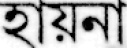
হায়না
